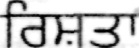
ਰਿਸ਼ਤਾ
